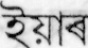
ইয়াৰ
